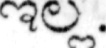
ಇಲ್ಲ.
